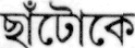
ছাঁটোকে
